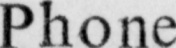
Phone
